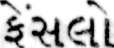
ફેંસલો
